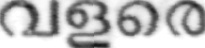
വളരെ
